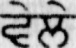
ਵੇਲੇ
